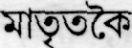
মাতৃতকৈ
